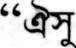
“ঐসু
